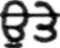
ਉਤੇ
